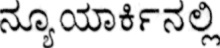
ನ್ಯೂಯಾರ್ಕಿನಲ್ಲಿ
